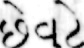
છેવટે
